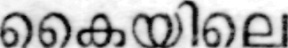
കൈയിലെ
